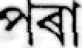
পৰা
